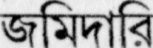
জমিদারি
